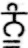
ਨੂੰ
